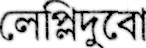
লেপ্লিদুবো
